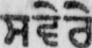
ਸਵੇਰੇ
